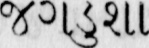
જગડુશા
